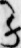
કે
